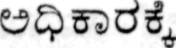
ಅಧಿಕಾರಕ್ಕೆ
